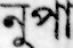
নুপা
